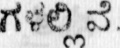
ಗಳಲ್ಲಿವೆ.
